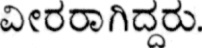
ವೀರರಾಗಿದ್ದರು.
